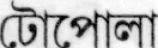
টোপোলা
